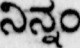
ನಿನ್ನಂ
